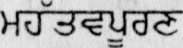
ਮਹੱਤਵਪੂਰਣ
